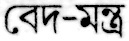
বেদ-মন্ত্র
